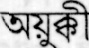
অয়ুক্কী
